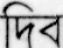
দিব
